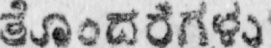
ತೊಂದರೆಗಳು
